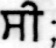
ਸੀ;
